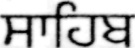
ਸਾਹਿਬ
